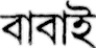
বাবাই
